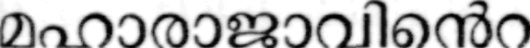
മഹാരാജാവിന്റെ
